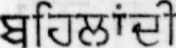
ਬਹਿਲਾਂਦੀ
